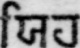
ਯਿਹ
